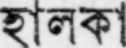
হালকা
